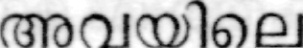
അവയിലെ
